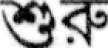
শুরু
